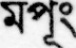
মপূং
